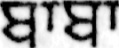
ਬਾਬਾ
